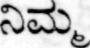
ನಿಮ್ಮ
